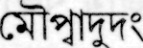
মৌপ্বাদুদং
